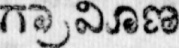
ಗ್ರಾಮೀಣ
